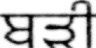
ਬੜੀ
